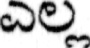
ಎಲ್ಲ
